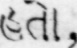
હતો.
